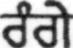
ਰੰਗੇ
